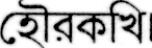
হৌরকখি।
